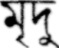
মৃদু
